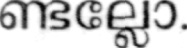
ണ്ടല്ലോ.
